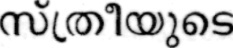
സ്ത്രീയുടെ
